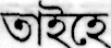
তাইহে
